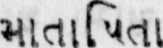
માતાપિતા
